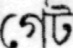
গেট
